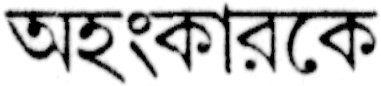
অহংকারকে
